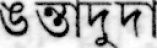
ঙন্তাদুদা
